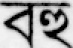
বহু
